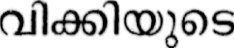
വിക്കിയുടെ
